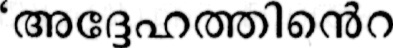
'അദ്ദേഹത്തിന്റെ
